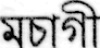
মচাগী
